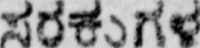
ಸರಕುಗಳ
